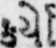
કર્યો
